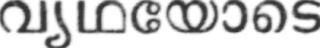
വ്യഥയോടെ
